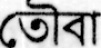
তৌবা
